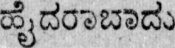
ಹೈದರಾಬಾದು
